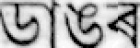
ডাঙৰ
